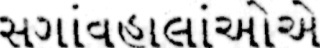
સગાંવહાલાંઓએ
